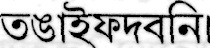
তঙাইফদবনি।
